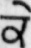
ਕੇ
